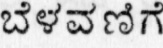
ಬೆಳವಣಿಗೆ
